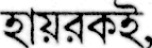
হায়রকই,
